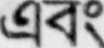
এবং
